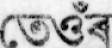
তেওঁৰ
